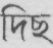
দিছ
